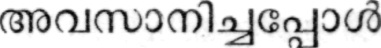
അവസാനിച്ചപ്പോള്‍
